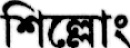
শিল্লোং
